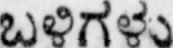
ಬಳಿಗಳು
